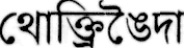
থোক্ত্রিঙৈদা
